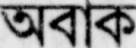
অবাক
